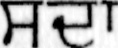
ਸਦਾ
